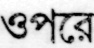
ওপরে
